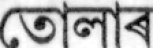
তোলাৰ
